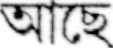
আছে
